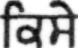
ਕਿਸੇ
